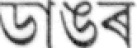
ডাঙৰ
